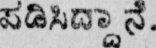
ಪಡಿಸಿದ್ದಾನೆ.
